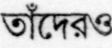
তাঁদেরও
